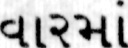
વારમાં
